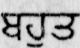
ਬਹੁਤ
